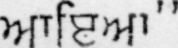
ਆਇਆ''
